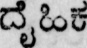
ದೈಹಿಕ
